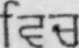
ਵਿਚ
